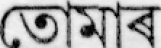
তোমাৰ
